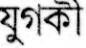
যুগকী
